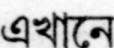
এখানে
